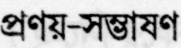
প্রণয়-সম্ভাষণ
